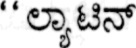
"ಲ್ಯಾಟಿನ್
